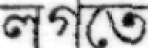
লগতে
